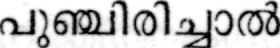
പുഞ്ചിരിച്ചാല്‍
